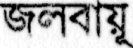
জলবায়ূ
